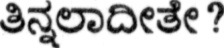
ತಿನ್ನಲಾದೀತೇ?
